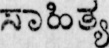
ಸಾಹಿತ್ಯ
